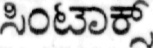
ಸಿಂಟಾಕ್ಸ್
